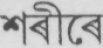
শৰীৰে
